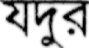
যদুর
